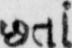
છતાં
